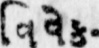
વિવેક-
